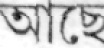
আছে
